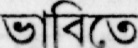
ভাবিতে
